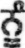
ਨੂੰ
